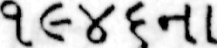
૧૯૪૬ના
